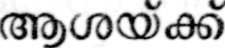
ആശയ്ക്ക്
